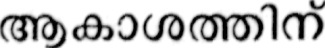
ആകാശത്തിന്
